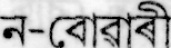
ন-বোৱাৰী
